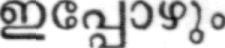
ഇപ്പോഴും
